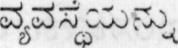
ವ್ಯವಸ್ಥೆಯನ್ನು
